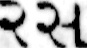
રસ
